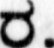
ರ.
